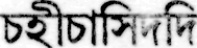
চহীচাসিদদি
